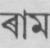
ৰাম
